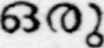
ഒരു
